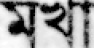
মখা
